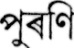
পুৰণি
